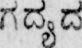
ಗದ್ಯದ
